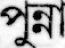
পুন্না
